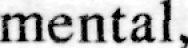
mental,
